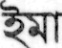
ইমা
